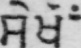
ਸੇਖੋਂ
